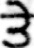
ਤੇ
